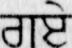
ਗਏ
